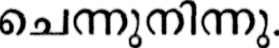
ചെന്നുനിന്നു.
